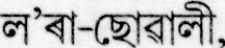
ল'ৰা-ছোৱালী,
